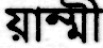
য়াম্মী
